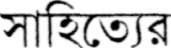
সাহিত্যের
